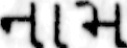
નામ
